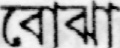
বোঝা
